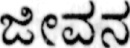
ಜೀವನ
